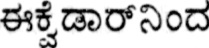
ಈಕ್ವೆಡಾರ್ ನಿಂದದ
